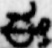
ಈ
